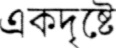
একদৃষ্টে
